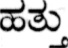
ಹತ್ತು
